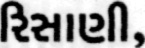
રિસાણી,
